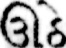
ઊઠે
